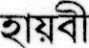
হায়বী
